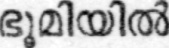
ഭൂമിയില്‍
